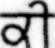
ਕੀ
